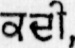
ਕਦੀ,
